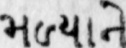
મળ્યાને
